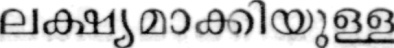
ലക്ഷ്യമാക്കിയുള്ള
